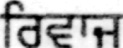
ਰਿਵਾਜ
